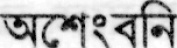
অশেংবনি
